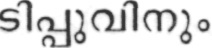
ടിപ്പുവിനും
